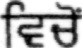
ਵਿਚੋਂ
